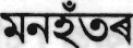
মনহঁতৰ
